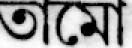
তামো
